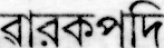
ৱারকপদি
